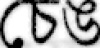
চেঙ
